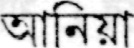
আনিয়া
